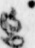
હું
